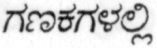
ಗಣಕಗಳಲ್ಲಿ
